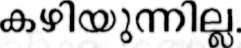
കഴിയുന്നില്ല.
